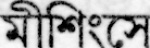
মীশিংসে
